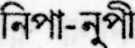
নিপা-নুপী
